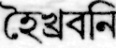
হৈখ্রবনি
